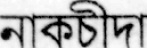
নাকচীদা
